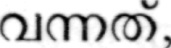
വന്നത്,
